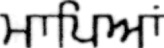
ਮਾਪਿਆਂ
